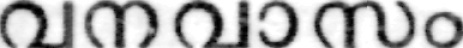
വനവാസം
